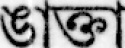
ঙাক্তা
